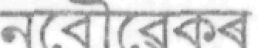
নবৌৱেকৰ
